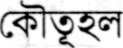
কৌতূহল
